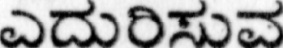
ಎದುರಿಸುವ
